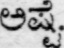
ಅಷ್ಟೆ.
